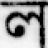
ল
